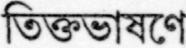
তিক্তভাষণে
